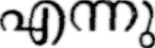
എന്നു
